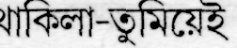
থাকিলা-তুমিয়েই
